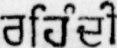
ਰਹਿੰਦੀ
